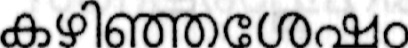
കഴിഞ്ഞശേഷം
